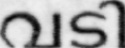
വടി
